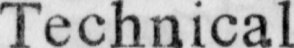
Technical
